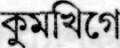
কুমখিগে
